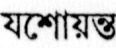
যশোয়ন্ত
